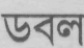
ডবল
